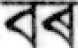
বৰ
